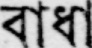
বাধা
